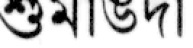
শুমাঙদা
